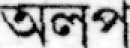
অলপ
